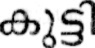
കുട്ടി
